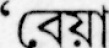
'বেয়া
